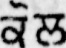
ਕੋਲ
